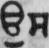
ਉਸ
